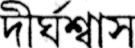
দীর্ঘশ্বাস
